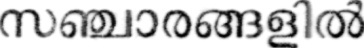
സഞ്ചാരങ്ങളില്‍
